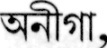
অনীগা,
